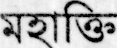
মহাক্তি
